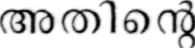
അതിന്റെ
